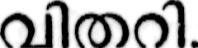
വിതറി.
